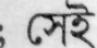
;সেই
